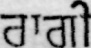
ਰਾਗੀ
